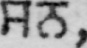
ਸਨ,
